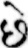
છે
